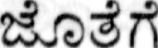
ಜೊತೆಗೆ
